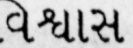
વિશ્વાસ
